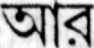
আর
